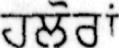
ਹਲੋਰਾਂ
